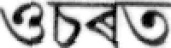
ওচৰত
